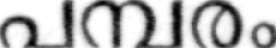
പമ്പരം
